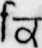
ਕਿ
